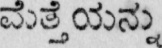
ಮೆತ್ತೆಯನ್ನು
